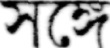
সঙ্গে
